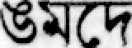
ঙমদে
